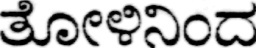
ತೋಳಿನಿಂದ
